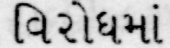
વિરોધમાં
